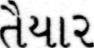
તૈયાર
